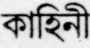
কাহিনী
